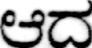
ಆದ
